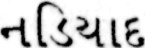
નડિયાદ
